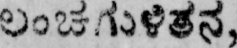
ಲಂಚಗುಳಿತನ,
